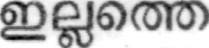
ഇല്ലത്തെ
